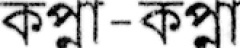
কপ্না-কপ্না
